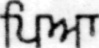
ਪਿਆ
